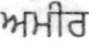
ਅਮੀਰ
